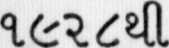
૧૯૨૮થી
